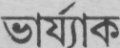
ভাৰ্য্যাক
